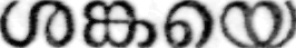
ശങ്കയെ
